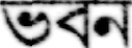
ভবন
